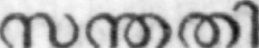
സന്തതി
